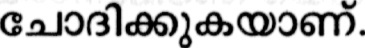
ചോദിക്കുകയാണ്.
